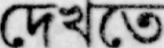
দেখতে
